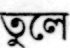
তুলে
